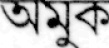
অমুক
